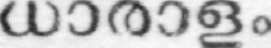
ധാരാളം
